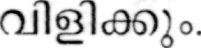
വിളിക്കും.
